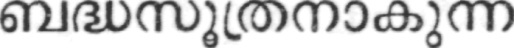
ബദ്ധസൂത്രനാകുന്ന
